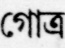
গোত্র
